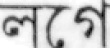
লগে
